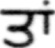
ਤਾਂ
